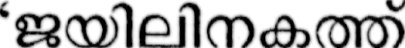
'ജയിലിനകത്ത്
